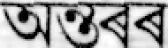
অন্তৰৰ
